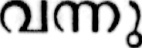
വന്നു
